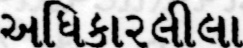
અઘિકારલીલા
